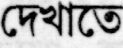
দেখাতে
